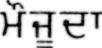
ਮੌਜੂਦਾ
